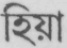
হিয়া
